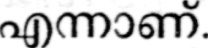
എന്നാണ്.
